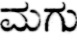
ಮಗು
